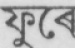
ফুৰে
